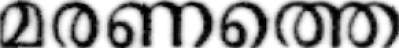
മരണത്തെ
